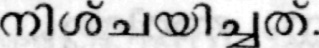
നിശ്ചയിച്ചത്.
